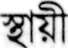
স্থায়ী
